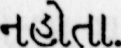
નહોતા.
